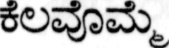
ಕೆಲವೊಮ್ಮೆ
